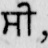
ਸੀ,
